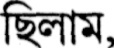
ছিলাম,
